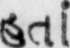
હતાં
